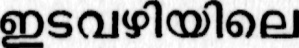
ഇടവഴിയിലെ
